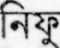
নিফু
